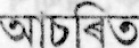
আচৰিত
